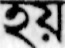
হয়
